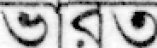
ভারত
